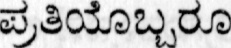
ಪ್ರತಿಯೊಬ್ಬರೂ
